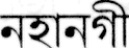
নহানগী
